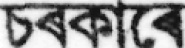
চৰকাৰে
